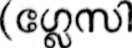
(ഗ്ലേസി
